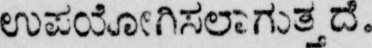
ಉಪಯೋಗಿಸಲಾಗುತ್ತದೆ.
